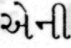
એની
